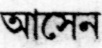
আসেন
